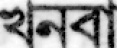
খনবা
